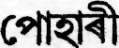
পোহাৰী
